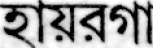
হায়রগা
